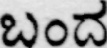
ಬಂದ
